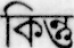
কিন্তু
